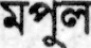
মপুল
